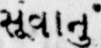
સૂવાનું
